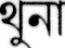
থুনা
